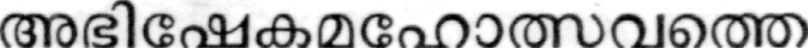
അഭിഷേകമഹോത്സവത്തെ
